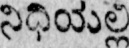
ನಿಧಿಯಲ್ಲಿ
